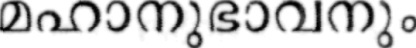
മഹാനുഭാവനും
